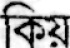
কিয়
